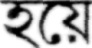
হয়ে
